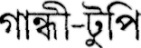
গান্ধী-টুপি
